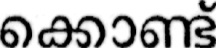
ക്കൊണ്ട്
